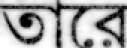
তারে
